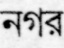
নগর
